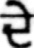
ਦੇ
